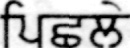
ਪਿਛਲੇ
